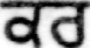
ਕਰ
